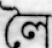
লৈ
